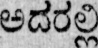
ಅದರಲ್ಲಿ
